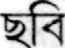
ছবি
